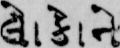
લોકોને
